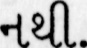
નથી.
